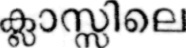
ക്ലാസ്സിലെ
